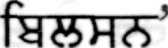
ਬਿਲਸਨ'
